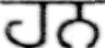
ਹਨ
